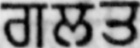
ਗਲਤ
